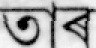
তাৰ
